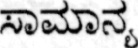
ಸಾಮಾನ್ಯ
